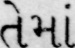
તેમાં
